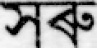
সৰু
